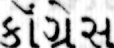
કૉંગ્રેસ
